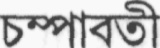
চম্পাবতী
